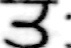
ਤ:
